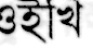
ওইখি
